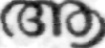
ആ
